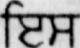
ਇਸ
